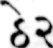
ઠેર
